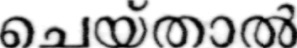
ചെയ്താല്‍
